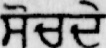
ਸੋਚਦੇ
